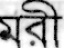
মরী
